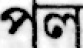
পল
